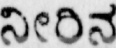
ನೀರಿನ
